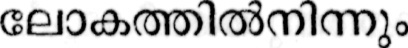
ലോകത്തില്‍നിന്നും
